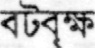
বটবৃক্ষ
